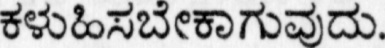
ಕಳುಹಿಸಬೇಕಾಗುವುದು.
